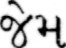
જેમ
